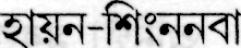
হায়ন-শিংননবা
